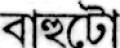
বাহুটো
